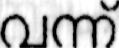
വന്ന്
